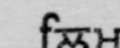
ਲਿਮ
